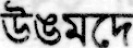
উঙমদে
